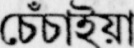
চেঁচাইয়া
